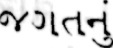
જગતનું
